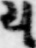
ય
